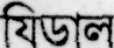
যিডাল
